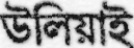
উলিয়াই
